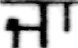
ਜਾ
